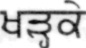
ਖੜ੍ਹਕੇ
